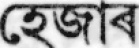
হেজাৰ
